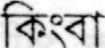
কিংবা
